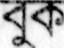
বুক
